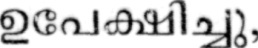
ഉപേക്ഷിച്ചു,
